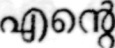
എന്റെ
